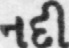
નદી
